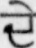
ਦੇ
